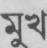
মুখ
